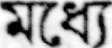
মধ্যে
